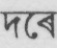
দৰে
